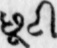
છૂટી
